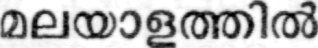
മലയാളത്തില്‍
